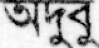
অদুবু
